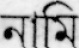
নামি
